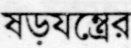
ষড়যন্ত্রের
